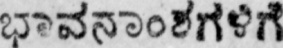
ಭಾವನಾಂಶಗಳಿಗೆ
